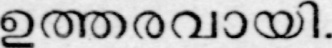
ഉത്തരവായി.
